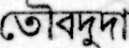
তৌবদুদা
